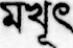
মখূৎ
